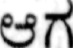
ಆಗ
